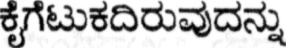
ಕೈಗೆಟುಕದಿರುವುದನ್ನು
